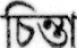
চিন্তা
